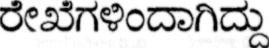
ರೇಖೆಗಳಿಂದಾಗಿದ್ದು
